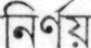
নির্ণয়
